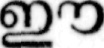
ഈ
